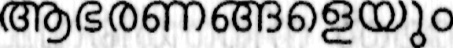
ആഭരണങ്ങളെയും
